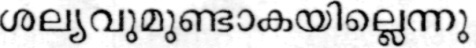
ശല്യവുമുണ്ടാകയില്ലെന്നു
